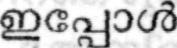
ഇപ്പോള്‍
